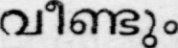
വീണ്ടും
